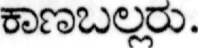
ಕಾಣಬಲ್ಲರು.
